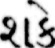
શકે
